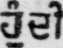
ਹੁੰਦੀ
